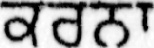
ਕਰਨਾ
